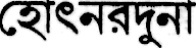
হোৎনরদুনা
